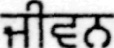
ਜੀਵਨ
